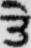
ਤੇ
